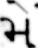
મેં
